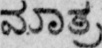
ಮಾತ್ರ
